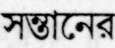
সন্তানের
